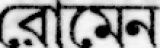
রোমেন
